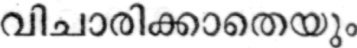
വിചാരിക്കാതെയും
